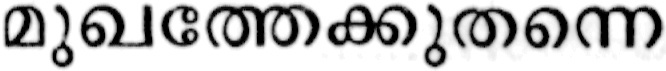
മുഖത്തേക്കുതന്നെ
